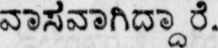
ವಾಸವಾಗಿದ್ದಾರೆ.
